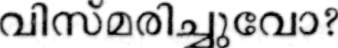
വിസ്മരിച്ചുവോ?
